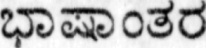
ಭಾಷಾಂತರ
